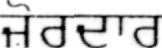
ਜ਼ੋਰਦਾਰ
